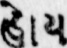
હોય
